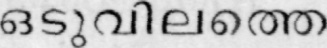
ഒടുവിലത്തെ
